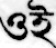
ওই
